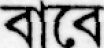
বাবে
